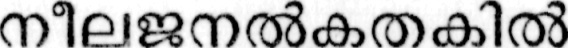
നീലജനല്‍കതകില്‍
